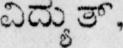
ವಿದ್ಯುತ್,
